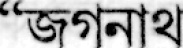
“জগনাথ
